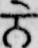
ਨੇ
